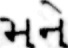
મને
